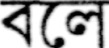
বলে
